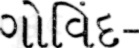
ગોવિંદ-
